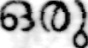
ഒരു
